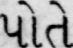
પોતે
